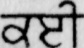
ਕਈ
